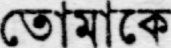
তোমাকে
